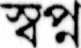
স্বপ্ন
